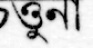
চত্তুনা
